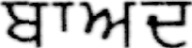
ਬਾਅਦ
